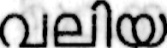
വലിയ
